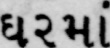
ઘરમાં
